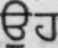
ਉਹ
